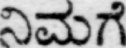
ನಿಮಗೆ
